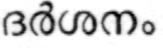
ദര്‍ശനം
